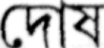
দোষ
